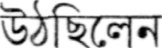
উঠছিলেন
